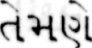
તેમણે
